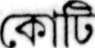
কোটি
